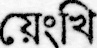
য়েংখি
